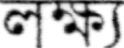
লক্ষ্য
